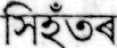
সিহঁতৰ
